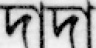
দাদা
